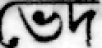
ভেদ
